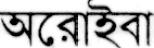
অরোইবা
